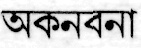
অকনবনা
